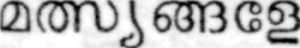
മത്സ്യങ്ങളേ
